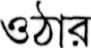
ওঠার
